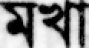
মখা
